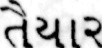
તૈયાર
